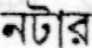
নটার
